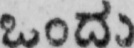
ಒಂದು
